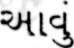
આવું
